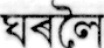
ঘৰলৈ
